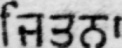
ਜਿਤਨਾ
